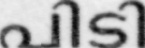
പിടി
